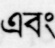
এবং
